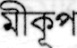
মীকূপ
